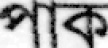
পাক
